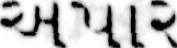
અપાર
